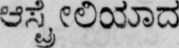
ಆಸ್ಟ್ರೇಲಿಯಾದ
